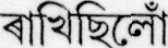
ৰাখিছিলোঁ
